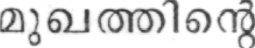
മുഖത്തിന്റെ
